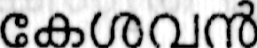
കേശവന്‍
